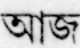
আজ
